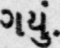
ગયું.
